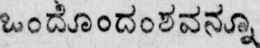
ಒಂದೊಂದಂಶವನ್ನೂ
